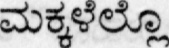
ಮಕ್ಕಳೆಲ್ಲೊ
